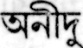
অনীদু
